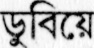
ডুবিয়ে
